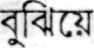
বুঝিয়ে
